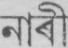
নাৰী
